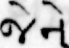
જેને
